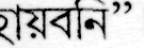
হায়বনি”
